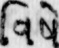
વિષે
